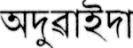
অদুৱাইদা
